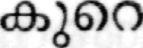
കുറെ
